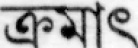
ক্রমাৎ
